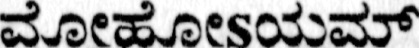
ಮೋಹೋsಯಮ್
